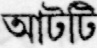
আটটি
